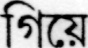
গিয়ে
